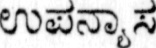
ಉಪನ್ಯಾಸ
